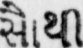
સૌથી
